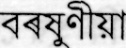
বৰষুণীয়া
